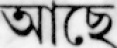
আছে
